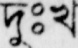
দুঃখ
